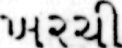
ખરચી
